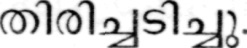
തിരിച്ചടിച്ചു.
